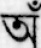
অঁ
